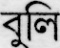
বুলি
